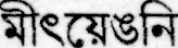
মীৎয়েঙনি
